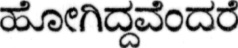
ಹೋಗಿದ್ದವೆಂದರೆ
